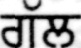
ਗੱਲ
